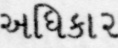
અધિકાર
